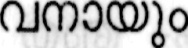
വനായും
